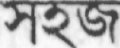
সহজ
